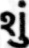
શું
